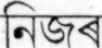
নিজৰ
